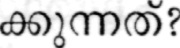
ക്കുന്നത്?
